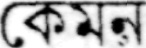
কেমন
